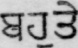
ਬਹੁਤੇ
